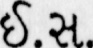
ઈ.સ.
